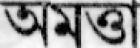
অমত্তা
